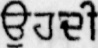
ਉਹਦੀ
